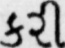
કરી
